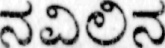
ನವಿಲಿನ
